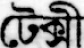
টেক্সী
